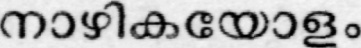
നാഴികയോളം
